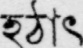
হঠাৎ
